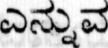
ಎನ್ನುವ
